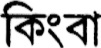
কিংবা
